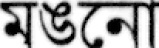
মঙনো
